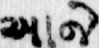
આજે
